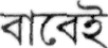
বাবেই
